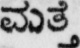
ಮತ್ತೆ
